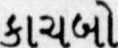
કાચબો
